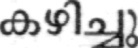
കഴിച്ചു
